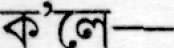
ক'লে-
